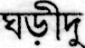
ঘড়ীদু
